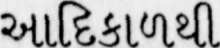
આદિકાળથી
